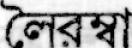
লৈরম্বা
